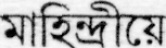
মাহিন্দ্রীয়ে
